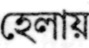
হেলায়
